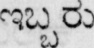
ಇಬ್ಬರು
